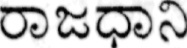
ರಾಜಧಾನಿ
